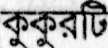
কুকুরটি
